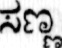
ಸಣ್ಣ
